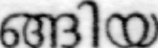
ങ്ങിയ
